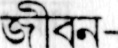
জীবন-
